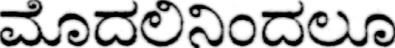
ಮೊದಲಿನಿಂದಲೂ
